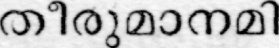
തീരുമാനമി
